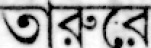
তারুরে
